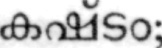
കഷ്ടം;
